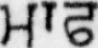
ਮਾਫ
